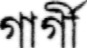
গার্গী
